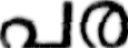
പര
